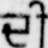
ਦੀ
